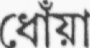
ধোঁয়া
